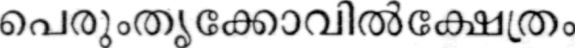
പെരുംതൃക്കോവില്‍ക്ഷേത്രം
